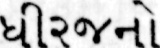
ધીરજનો
